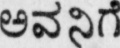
ಅವನಿಗೆ
